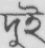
দুই
